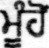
ਮੂੰਹੋਂ
